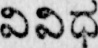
ವಿವಿಧ
